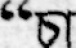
“চা
